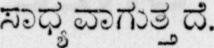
ಸಾಧ್ಯವಾಗುತ್ತದೆ.
